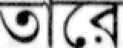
তারে
